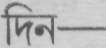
দিন-
